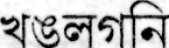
খঙলগনি
